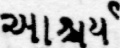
આશ્ચર્ય
